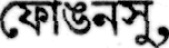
ফোঙনসু,
